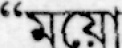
"ময়ো
